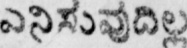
ಎನಿಸುವುದಿಲ್ಲ
